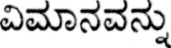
ವಿಮಾನವನ್ನು
